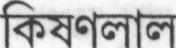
কিষণলাল
